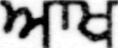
ਆਖ
